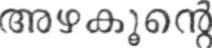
അഴകൂന്റെ
